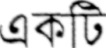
একটি
